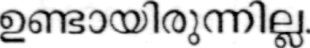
ഉണ്ടായിരുന്നില്ല.
